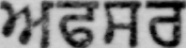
ਅਫਸਰ
